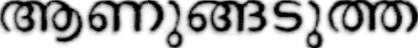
ആണുങ്ങടുത്ത
